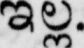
ಇಲ್ಲ.
